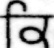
ਕਿ
